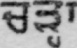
ਚੜ੍ਹਾ
